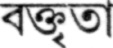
বক্তৃতা
